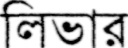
লিভার
